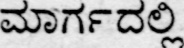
ಮಾರ್ಗದಲ್ಲಿ
